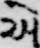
એ
